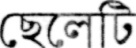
ছেলেটি
